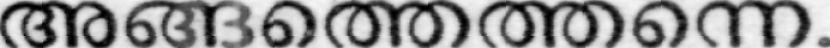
അങ്ങത്തെത്തന്നെ.
